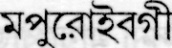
মপুরোইবগী
